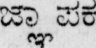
ಜ್ಞಾಪಕ
